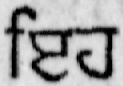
ਇਹ
